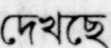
দেখছে
